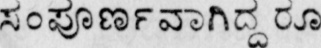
ಸಂಪೂರ್ಣವಾಗಿದ್ದರೂ
